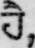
ਹੈ,
